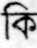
কি
